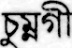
চুম্নগী
